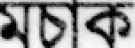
মচাক
